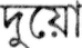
দুয়ো
